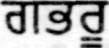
ਗਭਰੂ
